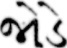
જોડે
